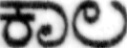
ಕಾಲ
